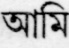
আমি
